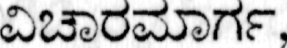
ವಿಚಾರಮಾರ್ಗ,
